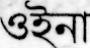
ওইনা
